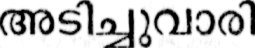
അടിച്ചുവാരി
